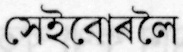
সেইবোৰলৈ
